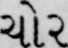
ચોર
